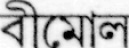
বীমোল
